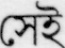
সেই
